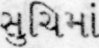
સુચિમાં
